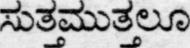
ಸುತ್ತಮುತ್ತಲೂ
